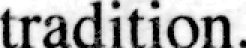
tradition.
